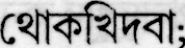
থোকখিদবা;
